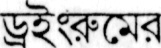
ড্রইংরুমের
